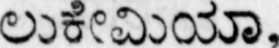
ಲುಕೇಮಿಯಾ,
